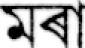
মৰা
